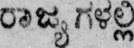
ರಾಜ್ಯಗಳಲ್ಲಿ
